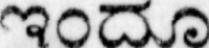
ಇಂದೂ
